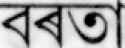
বৰতা
